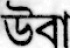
উবা
